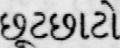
છૂટછાટો
